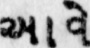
આવે
